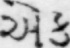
એક
